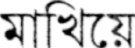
মাখিয়ে
